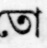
তো
